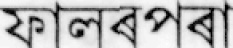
ফালৰপৰা
